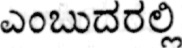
ಎಂಬುದರಲ್ಲಿ
